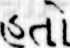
હતો
